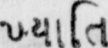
ખ્યાતિ
